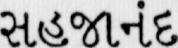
સહજાનંદ
